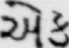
એક
